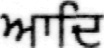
ਆਦਿ
